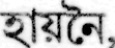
হায়নৈ,
